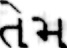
તેમ
